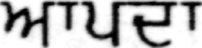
ਆਪਦਾ
